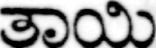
ತಾಯಿ
